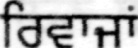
ਰਿਵਾਜਾਂ
